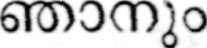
ഞാനും
